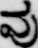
ವು
